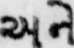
અને
